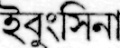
ইবুংসিনা
